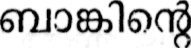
ബാങ്കിന്റെ
